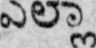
ಎಲ್ಲಾ
